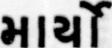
માર્યો
